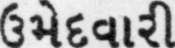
ઉમેદવારી
